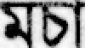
মচা
